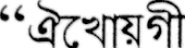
“ঐখোয়গী
